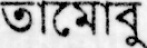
তামোবু
